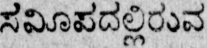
ಸಮೀಪದಲ್ಲಿರುವ
